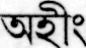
অহীং
